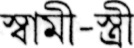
স্বামী-স্ত্রী
